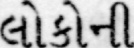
લોકોની
